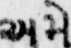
અમે
